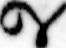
જ
